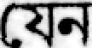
যেন
